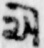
એ
